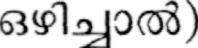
ഒഴിച്ചാല്‍)
